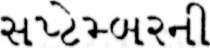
સપ્ટેમ્બરની
